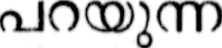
പറയുന്ന
